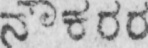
ನೌಕರರ
